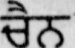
ਚੈਨ
